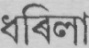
ধৰিলা
